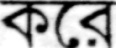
করে
